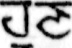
ਹੁਣ
